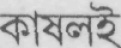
কাষলই
